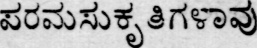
ಪರಮಸುಕೃತಿಗಳಾವು
